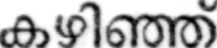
കഴിഞ്ഞ്
